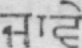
ਜਾਵੇ
